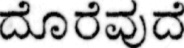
ದೊರೆವುದೆ
